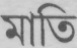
মাতি
